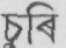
চুৰি
